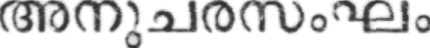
അനുചരസംഘം
